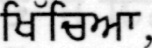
ਖਿੱਚਿਆ,
